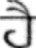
ਹੈ
